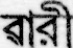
ৱারী
